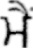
ਮੈਂ
